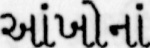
આંખોનાં
